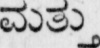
ಮತ್ತು
